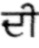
ਦੀ
